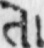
તો
